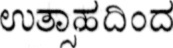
ಉತ್ಸಾಹದಿಂದ
